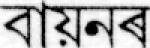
বায়নৰ
